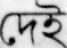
দেই
